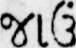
જાઉં
